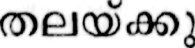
തലയ്ക്കു
